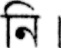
নি।
